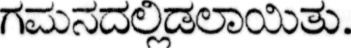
ಗಮನದಲ್ಲಿಡಲಾಯಿತು.
